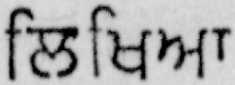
ਲਿਖਿਆ
